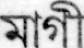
মাগী
